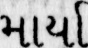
માર્યા
